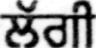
ਲੱਗੀ
